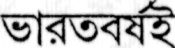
ভারতবর্ষই
